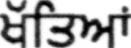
ਖੱਤਿਆਂ
